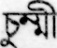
চুম্মী
